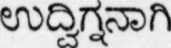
ಉದ್ವಿಗ್ನನಾಗಿ
